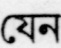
যেন
